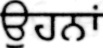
ਉਹਨਾਂ
